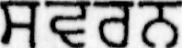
ਸਵਰਨ
